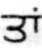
ਤਾਂ
